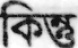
কিন্তু
